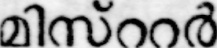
മിസ്ററര്‍
